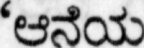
‘ಆನೆಯ
